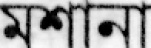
মশানা
